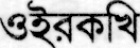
ওইরকখি
